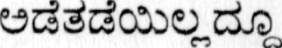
ಅಡೆತಡೆಯಿಲ್ಲದ್ದೂ
